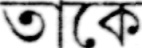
তাকে
